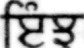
ਇੰਝ
